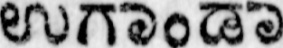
ಉಗಾಂಡಾ
